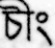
চীং
